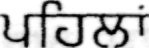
ਪਹਿਲਾਂ
